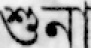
শুনা
